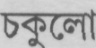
চকুলো
